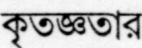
কৃতজ্ঞতার
